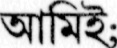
আমিই;
